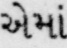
એમાં
